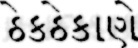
ઠેકઠેકાણે
